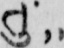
તું
